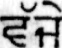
ਵੱਜੇ
